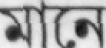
মানে
